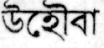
উহৌবা
